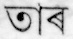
তাৰ
